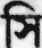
সি
